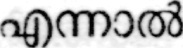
എന്നാല്‍
